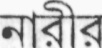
নারীর
